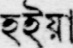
হইয়া
